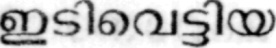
ഇടിവെട്ടിയ
